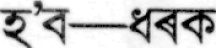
হ'ব-ধৰক
